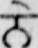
ਨੇ
